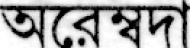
অরেম্বদা
